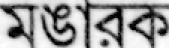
মঙারক
